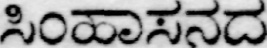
ಸಿಂಹಾಸನದ
